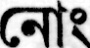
নোং
